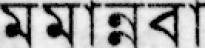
মমান্নবা
